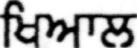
ਖਿਆਲ
